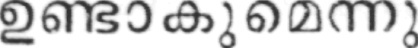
ഉണ്ടാകുമെന്നു
